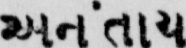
અનંતાય
